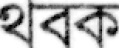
থবক
